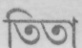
তিতা
